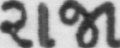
રાજા
